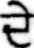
ਦੇ
